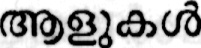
ആളുകള്‍
